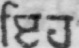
ਇਹ
